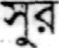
সুর
